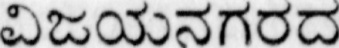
ವಿಜಯನಗರದ
